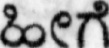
ಹೀಗೆ
